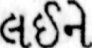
લઈને
